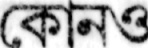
কোনও
